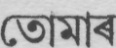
তোমাৰ
